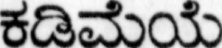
ಕಡಿಮೆಯೆ
